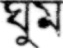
ঘুম
